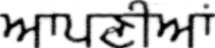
ਆਪਣੀਆਂ
